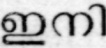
ഇനി
